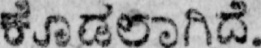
ಕೊಡಲಾಗಿದೆ.
